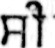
ਸੀ
